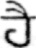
ਹੈ
